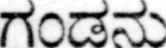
ಗಂಡನು
